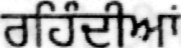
ਰਹਿੰਦੀਆਂ
